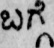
ಬಗ್ಗೆ
